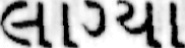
લાગ્યા
